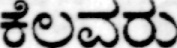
ಕೆಲವರು
